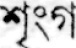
শৃংগ
